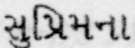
સુપ્રિમના
